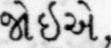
જોઈએ,
